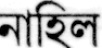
নাহিল
